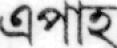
এপাহ
